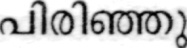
പിരിഞ്ഞു
